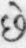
છે
